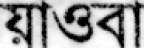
য়াওবা
